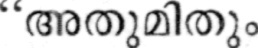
"അതുമിതും
